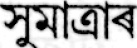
সুমাত্রাৰ
